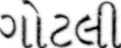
ગોટલી
